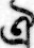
ঐ
